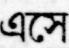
এসে
